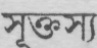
সূক্তস্য
